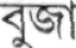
বুজা
